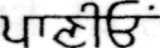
ਪਾਣੀਓਂ
